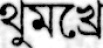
থুমখ্রে
